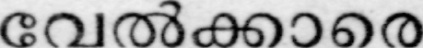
വേല്‍ക്കാരെ
